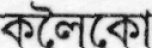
কলৈকো
